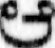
ಆ
